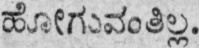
ಹೋಗುವಂತಿಲ್ಲ.
